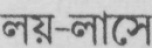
লয়-লাসে
